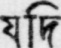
যদি
